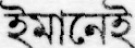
ইমানেই
